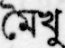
মৈখু
